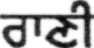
ਰਾਣੀ
